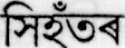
সিহঁতৰ
